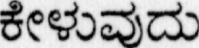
ಕೇಳುವುದು
